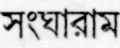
সংঘারাম
